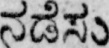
ನಡೆಸು
